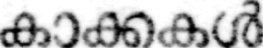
കാക്കകള്‍
